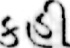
કહી
